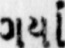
ગયા
